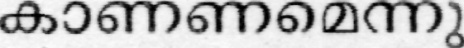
കാണണമെന്നു
